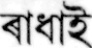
ৰাধাই
